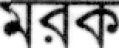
মরক
